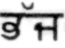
ਭੱਜ
